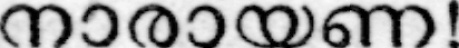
നാരായണ!
